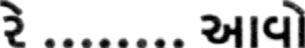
રે..........આવો
